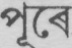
পূৰে
